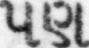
પણ
